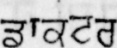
ਡਾਕਟਰ
